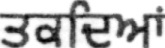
ਤਕਦਿਆਂ
